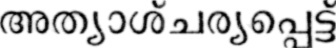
അത്യാശ്ചര്യപ്പെട്ട്
